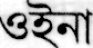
ওইনা
